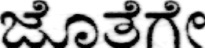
ಜೊತೆಗೇ
